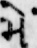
મેં
